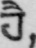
ਹੈ,
